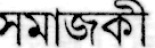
সমাজগী
